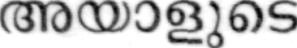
അയാളുടെ
